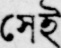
সেই
